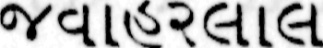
જવાહરલાલ
